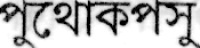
পুথোকপসু
